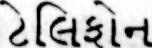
ટેલિફોન
